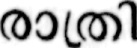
രാത്രി
